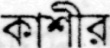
কাশীর
